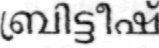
ബ്രിട്ടീഷ്
